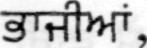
ਭਾਜੀਆਂ,
